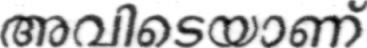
അവിടെയാണ്
